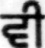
ਵੀ
